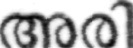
അരി
